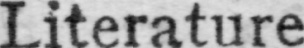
Literature
